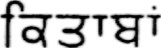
ਕਿਤਾਬਾਂ
